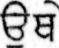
ਉਥੇ
